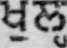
ਖੁਲ੍ਹ
